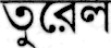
তুরেল
